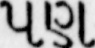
પણ
